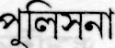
পুলিসনা
